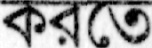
করতে
